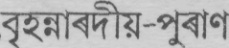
বৃহন্নাৰদীয়-পুৰাণ,
